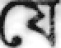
যে
